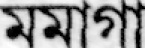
মমাগা
